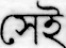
সেই
